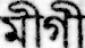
মীগী
